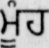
ਮੂੰਹ
